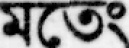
মতেং
